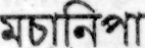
মচানিপা
